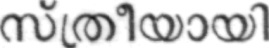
സ്ത്രീയായി
